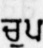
ਚੁਪ
